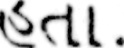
હતા.
